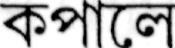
কপালে
